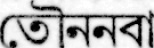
তৌননবা
